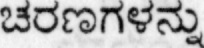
ಚರಣಗಳನ್ನು
